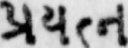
પ્રયત્ન
